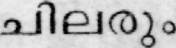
ചിലരും
